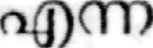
എന്ന
